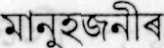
মানুহজনীৰ
